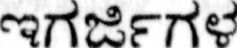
ಇಗರ್ಜಿಗಳ
